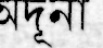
অদুনা
